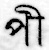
পী
